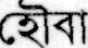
হৌবা
